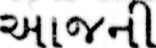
આજની
